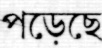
পড়েছে
